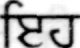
ਇਹ
